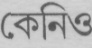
কেনিও
